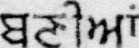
ਬਣੀਆਂ
